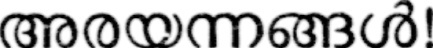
അരയന്നങ്ങള്‍!
